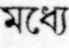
মধ্যে
